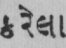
કરેલા
